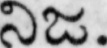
ನಿಜ.
